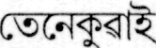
তেনেকুৱাই
